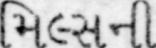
મિલ્સની
